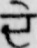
ਦੇ
